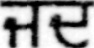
ਜਦ
